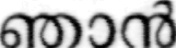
ഞാന്‍
